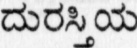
ದುರಸ್ತಿಯ
